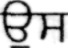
ਉਸ
